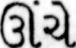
ઊંચે
